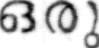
ഒരു
